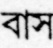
বাস
